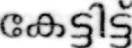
കേട്ടിട്ട്
